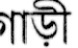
গাড়ী
